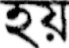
হয়
